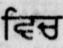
ਵਿਚ
